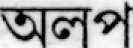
অলপ
